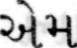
એમ
